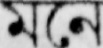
মনে
